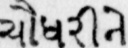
ચૌધરીને
